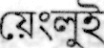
য়েংলুই
